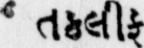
તકલીફ
